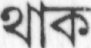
থাক
